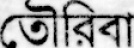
তৌরিবা
